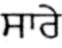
ਸਾਰੇ
